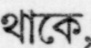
থাকে,
